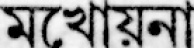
মখোয়না
